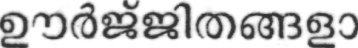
ഊര്‍ജ്ജിതങ്ങളാ
